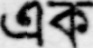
এক
